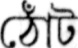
ঠোঁট
